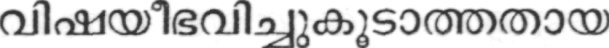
വിഷയീഭവിച്ചുകൂടാത്തതായ
